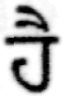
ਹੈ
